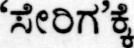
‘ಸೇರಿಗ’ಕ್ಕೆ
